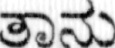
ತಾನು
